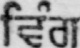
ਵਿੰਗ
